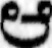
ಆ
